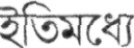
ইতিমধ্যে
